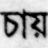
চায়
